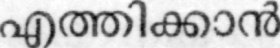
എത്തിക്കാന്‍
